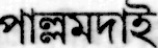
পাল্লকদাই
